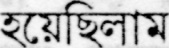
হয়েছিলাম
